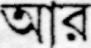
আর
